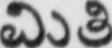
ಮಿತಿ
